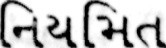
નિયમિત
